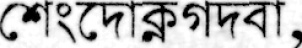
শেংদোক্লগদবা,
